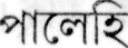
পালেহি
